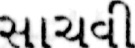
સાચવી
